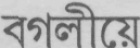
বগলীয়ে
